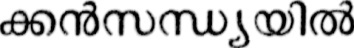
ക്കന്‍സന്ധ്യയില്‍
